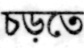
চড়তে
